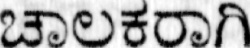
ಚಾಲಕರಾಗಿ
